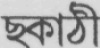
ছকাঠী
